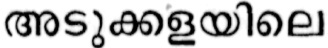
അടുക്കളയിലെ
